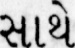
સાથે
